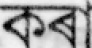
কৰা
